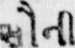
સૌની
